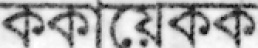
ককায়েকক
